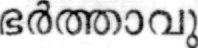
ഭര്‍ത്താവു
